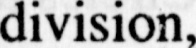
division,
